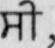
ਸੀ,
